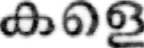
കളെ
